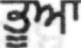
ਭੂਆ
